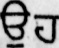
ਉਹ
